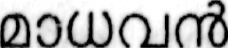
മാധവന്‍
